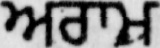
ਅਰਾਮ
